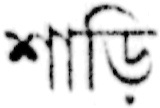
শাড়ি
